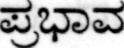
ಪ್ರಭಾವ
